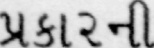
પ્રકારની
